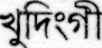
খুদিংগী
